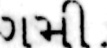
ગમી.
